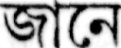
জানে
